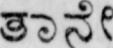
ತಾನೇ
